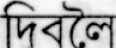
দিবলৈ
